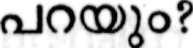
പറയും?
